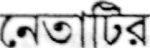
নেতাটির
